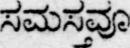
ಸಮಸ್ತವೂ
